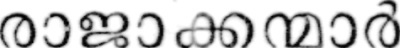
രാജാക്കന്മാര്‍
